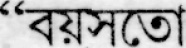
"বয়সতো
